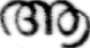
ആ
